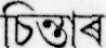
চিন্তাৰ
